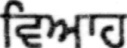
ਵਿਆਹ
